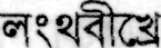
লংথবীখ্রে
